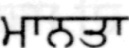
ਮਾਨਤਾ
